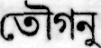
তৌগনু
